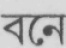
বনে
